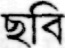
ছবি
